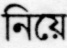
নিয়ে
